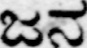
ಜನ
